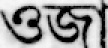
ওজা
